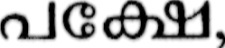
പക്ഷേ,
